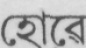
হোৱে
